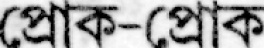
প্রোক-প্রোক
